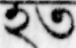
হত
